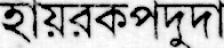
হায়রকপদুদা
